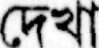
দেখা
